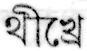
থীখ্রে
